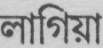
লাগিয়া
